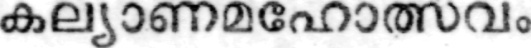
കല്യാണമഹോത്സവം
